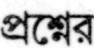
প্রশ্নের
